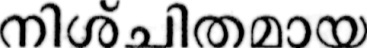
നിശ്ചിതമായ
